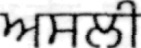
ਅਸਲੀ
